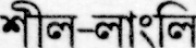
শীল-লাংলি
